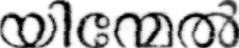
യിന്മേല്‍
